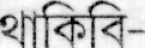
থাকিবি-
